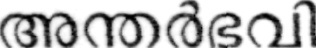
അന്തര്‍ഭവി
